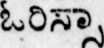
ಓರಿಸ್ಸಾ
